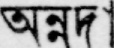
অন্নদা
